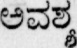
ಅವಶ್ಯ
